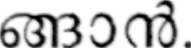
ങ്ങാന്‍.
